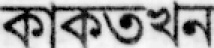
কাকতখন
